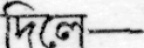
দিলে-
